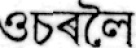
ওচৰলৈ
